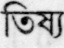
তিষ্য
